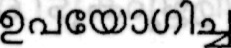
ഉപയോഗിച്ച
